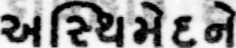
અસ્થિમેદને
